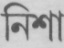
নিশা
